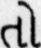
તો
